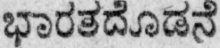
ಭಾರತದೊಡನೆ
